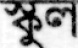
স্কুল
